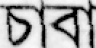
চাবা
